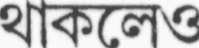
থাকলেও
